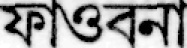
ফাওবনা
